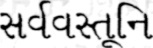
સર્વવસ્તૂનિ
